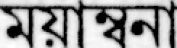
ময়াম্বনা
